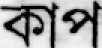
কাপ
